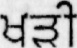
ਖੜੀ
